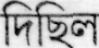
দিছিল
